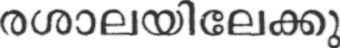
രശാലയിലേക്കു
